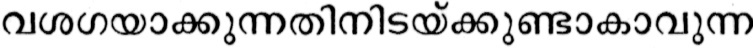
വശഗയാക്കുന്നതിനിടയ്ക്കുണ്ടാകാവുന്ന
